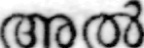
അല്‍
